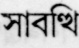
সাবত্থি
